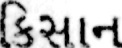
કિસાન
